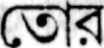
তোর
